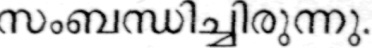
സംബന്ധിച്ചിരുന്നു.
